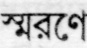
স্মরণে
